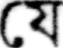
যে
